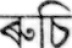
ৰুচি
